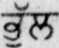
ਭੁੱਲ
